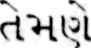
તેમણે
